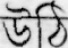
উঠি
